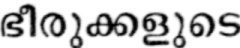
ഭീരുക്കളുടെ
